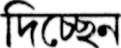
দিচ্ছেন
